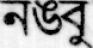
নঙবু
